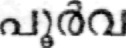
പൂര്‍വ
